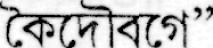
কৈদৌবগে”
